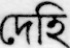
দেহি
